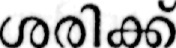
ശരിക്ക്
